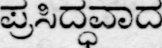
ಪ್ರಸಿದ್ಧವಾದ
